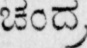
ಚಂದ್ರ
